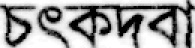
চৎকদবা
